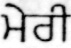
ਮੇਰੀ
